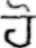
ਹੋ
